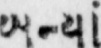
બન્યાં
